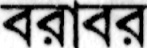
বরাবর
